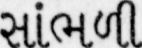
સાંભળી
